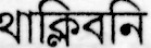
থাক্লিবনি
